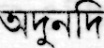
অদুনদি
